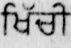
ਖਿੱਚੀ
